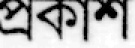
প্ৰকাশ
